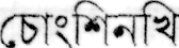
চোংশিনখি
